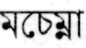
মচেম্না
